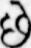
છે
